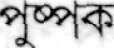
পুষ্পক
